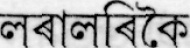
লৰালৰিকৈ
